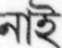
নাই
